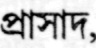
প্রাসাদ,
